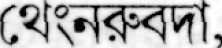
থেংনরুবদা,
